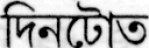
দিনটোত
